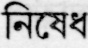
নিষেধ
